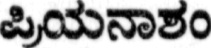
ಪ್ರಿಯನಾಶ೦
